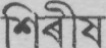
শিৰীষ
